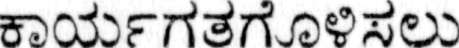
ಕಾರ್ಯಗತಗೊಳಿಸಲು
